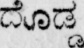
ದೊಡ್ಡ
